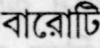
বারোটি
